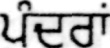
ਪੰਦਰਾਂ
